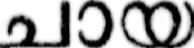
ചായ
